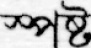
স্পষ্ট
